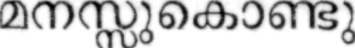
മനസ്സുകൊണ്ടു
